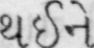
થઈને
